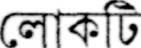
লোকটি
